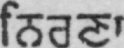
ਨਿਰਣਾ
